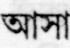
আসা
